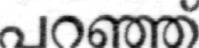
പറഞ്ഞ്
